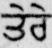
ਤੇਰੇ
